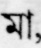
মা,
